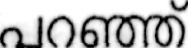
പറഞ്ഞ്
